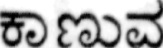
ಕಾಣುವ
